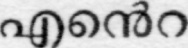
എന്റെ
